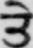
ਤੇ
